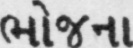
ભોજના
